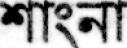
শাংনা
